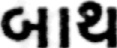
બાથ
